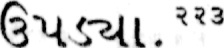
ઉપડ્યા.૨૨૩
